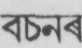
বচনৰ
